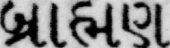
બ્રાહ્મણ
